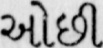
ઓછી
